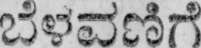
ಬೆಳವಣಿಗೆ
